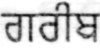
ਗਰੀਬ
